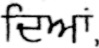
ਦਿਆਂ,
